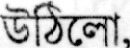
উঠিলো,
